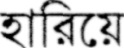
হারিয়ে
